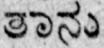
ತಾನು
